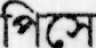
পিসে
